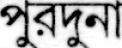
পুরদুনা
